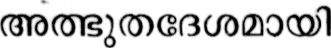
അത്ഭുതദേശമായി
